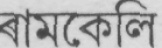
ৰামকেলি
